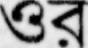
ওর
